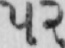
પર
